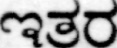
ಇತರ
